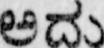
ಅದು
